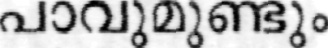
പാവുമുണ്ടും
